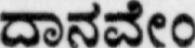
ದಾನವೇಂ
